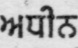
ਅਧੀਨ
